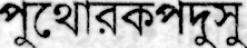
পুথোরকপদুসু
